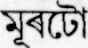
মূৰটো
